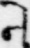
ને
